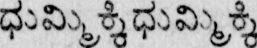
ಧುಮ್ಮಿಕ್ಕಿಧುಮ್ಮಿಕ್ಕಿ
